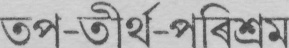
তপ-তীৰ্থ-পৰিশ্ৰম
